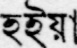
হইয়া
